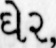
ઘેર,
